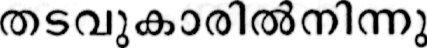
തടവുകാരില്‍നിന്നു
